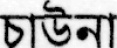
চাউনা
